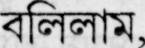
বলিলাম,
